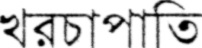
খরচাপাতি
